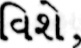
વિશે,
